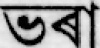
ভৰা
